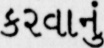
કરવાનું
